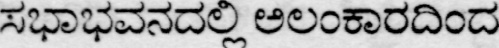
ಸಭಾಭವನದಲ್ಲಿಅಲಂಕಾರದಿಂದ
